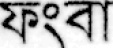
ফংবা
